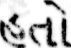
હતો
